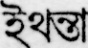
ইথন্তা
